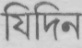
যিদিন
